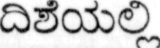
ದಿಶೆಯಲ್ಲಿ
